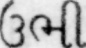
ઉભી
